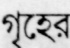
গৃহের
